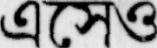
এসেও
